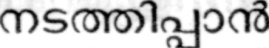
നടത്തിപ്പാന്‍
